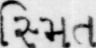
સ્મિત
